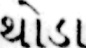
થોડા
